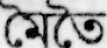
মৈতৈ
